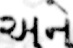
અને
